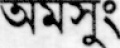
অমসুং
